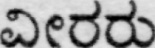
ವೀರರು
